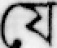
যে
